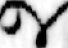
જ
